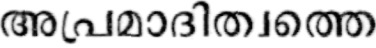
അപ്രമാദിത്വത്തെ
